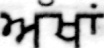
ਅੱਖਾਂ
